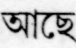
আছে
